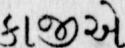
કાજીએ
